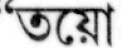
"তয়ো
